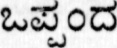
ಒಪ್ಪಂದ
